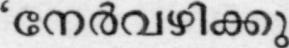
'നേര്‍വഴിക്കു
